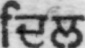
ਦਿਲ
